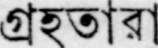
গ্রহতারা
